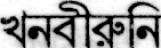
খনবীরুনি
